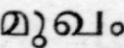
മുഖം
